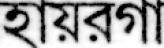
হায়রগা
